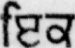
ਇਕ
